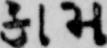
કામ
